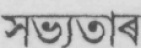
সভ্যতাৰ
